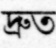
দ্রুত
